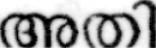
അതി
